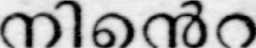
നിന്റെ
